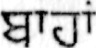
ਬਾਹਾਂ
